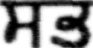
ਸਭ
